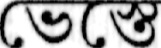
ভেস্তে
